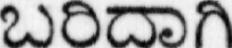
ಬರಿದಾಗಿ
